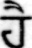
ਹੈ
